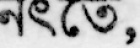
নৎতে,
